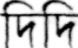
দিদি
